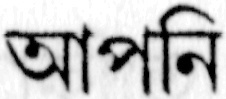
আপনি
